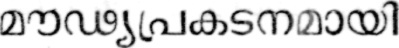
മൌഢ്യപ്രകടനമായി
